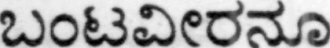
ಬಂಟವೀರನೂ
